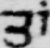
ਤਾਂ
